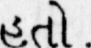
હતો.
